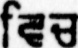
ਵਿਚ
